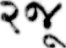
રજૂ
